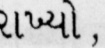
રાખ્યો,
